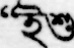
“ইশু
